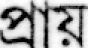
প্রায়
